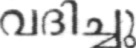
വദിച്ചു
